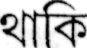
থাকি
